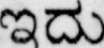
ಇದು
